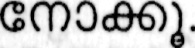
നോക്കൂ.
